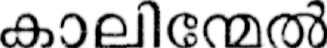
കാലിന്മേല്‍
